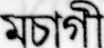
মচাগী
